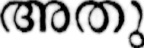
അതു
